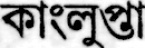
কাংলুপ্তা
